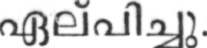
ഏല്പിച്ചു.
